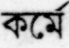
কর্মে
